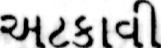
અટકાવી
